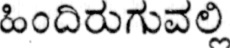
ಹಿಂದಿರುಗುವಲ್ಲಿ
